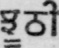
ਝੂਠੀ
